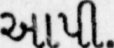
આપી.
